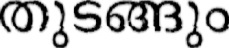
തുടങ്ങും
